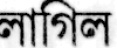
লাগিল
